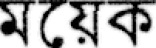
ময়েক
